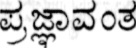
ಪ್ರಜ್ಞಾವಂತ
